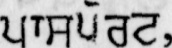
ਪਾਸਪੋਰਟ,
